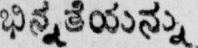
ಭಿನ್ನತೆಯನ್ನು
